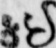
કઈ
